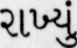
રાખ્યું
